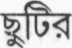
ছুটির
